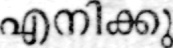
എനിക്കു
